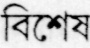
বিশেষ
